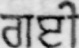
ਗਈ
